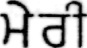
ਮੇਰੀ
